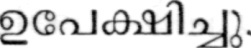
ഉപേക്ഷിച്ചു.
